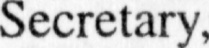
Secretary,
